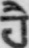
ਹੈ
